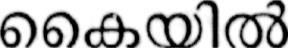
കൈയില്‍
